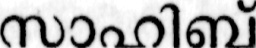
സാഹിബ്
